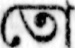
তো
